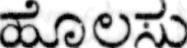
ಹೊಲಸು
